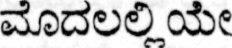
ಮೊದಲಲ್ಲಿಯೇ
